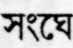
সংঘে
